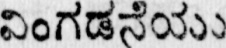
ವಿಂಗಡನೆಯು
